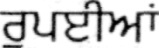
ਰੁਪਈਆਂ
